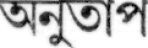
অনুতাপ
